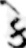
કે
